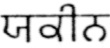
ਯਕੀਨ
